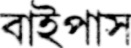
বাইপাস
